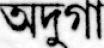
অদুগা
